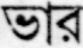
ভার
